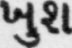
ખુશ
